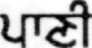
ਪਾਣੀ
